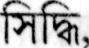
সিদ্ধি,
